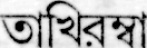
তাখিরম্বা
